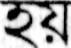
হয়
